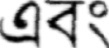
এবং
